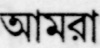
আমরা
